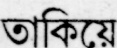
তাকিয়ে
